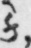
કે,
